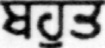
ਬਹੁਤ
